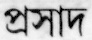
প্রসাদ
